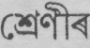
শ্রেণীৰ
